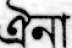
ঐনা
